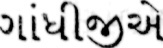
ગાંધીજીએ
